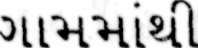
ગામમાંથી
